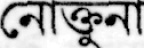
নোক্তুনা
